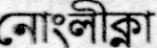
নোংলীক্না
